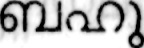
ബഹു
